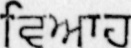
ਵਿਆਹ
